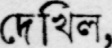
দেখিল,
